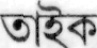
তাইক
